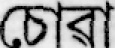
চোৱা
